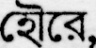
হৌরে,
